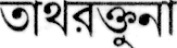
তাথরক্তুনা
